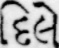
દિલે
